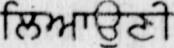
ਲਿਆਉਣੀ
